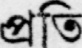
প্রতি
